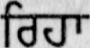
ਰਿਹਾ
